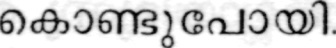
കൊണ്ടുപോയി.
